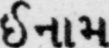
ઈનામ
